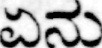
ಏನು
